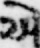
એ
